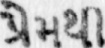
પ્રેમથી
